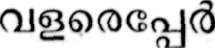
വളരെപ്പേര്‍
